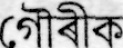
গৌৰীক
